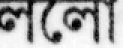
ললো
